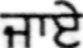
ਜਾਏ
